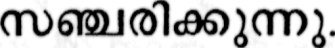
സഞ്ചരിക്കുന്നു.
